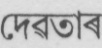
দেৱতাৰ
